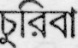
চুরিবা
